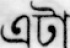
এটা
